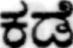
ಕಡೆ
